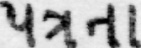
પત્રના
